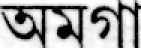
অমগা
